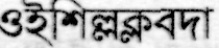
ওইশিল্লক্লবদা
